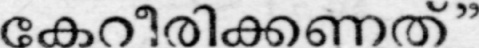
കേറീരിക്കണത്”
